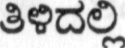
ತಿಳಿದಲ್ಲಿ
